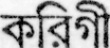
করিগী
